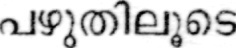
പഴുതിലൂടെ
